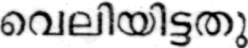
വെലിയിട്ടതു
